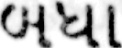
બધા
